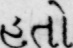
હતો
